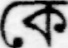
কে
